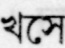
খসে
